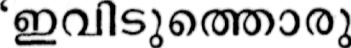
‘ഇവിടുത്തൊരു
